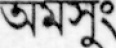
অমসুং
